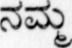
ನಮ್ಮ
